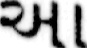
આ
